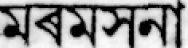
মৰমসনা
